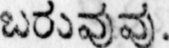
ಬರುವುವು.
